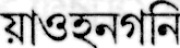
য়াওহনগনি
